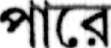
পারে
